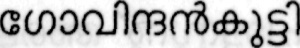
ഗോവിന്ദന്‍കുട്ടി
